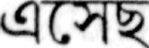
এসেছ
